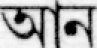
আন
